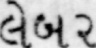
લેબર
